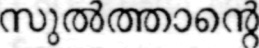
സുല്‍ത്താന്റെ
